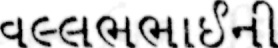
વલ્લભભાઈની
